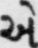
એ
